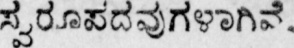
ಸ್ವರೂಪದವುಗಳಾಗಿವೆ.
